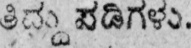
ತಿದ್ದುಪಡಿಗಳು.
